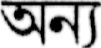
অন্য
